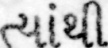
ત્યાંથી
